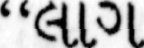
"લાગ
